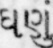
ઘણું
